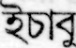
ইচাবু
